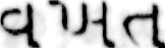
વખત
